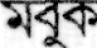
মবুক
